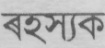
ৰহস্যক
